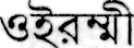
ওইরম্মী
